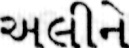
અલીને
